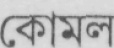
কোমল
